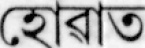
হোৱাত
